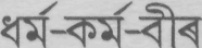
ধৰ্ম-কৰ্ম-বীৰ
